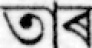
তাৰ
